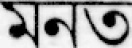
মনত
